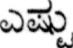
ಎಷ್ಟು
